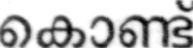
കൊണ്ട്
